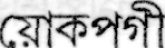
য়োকপগী
